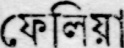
ফেলিয়া
